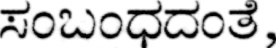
ಸಂಬಂಧದಂತೆ,
